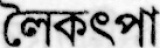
লৈকৎপা
